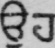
ਉਹ
